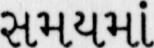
સમયમાં
